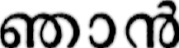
ഞാന്‍
